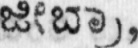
ಜೀಬ್ರಾ,
